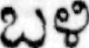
ಬಳಿ
